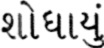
શોધાયું
